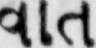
વાત
